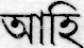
আহি
